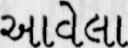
આવેલા
